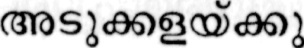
അടുക്കളയ്ക്കു
